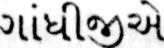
ગાંધીજીએ
